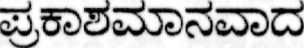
ಪ್ರಕಾಶಮಾನವಾದ
